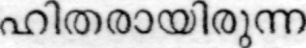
ഹിതരായിരുന്ന
